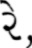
રે,
